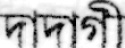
দাদাগী
